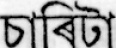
চাৰিটা
